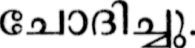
ചോദിച്ചു.
